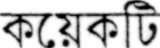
কয়েকটি
